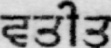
ਵਤੀਤ
